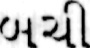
બચી
